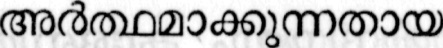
അര്‍ത്ഥമാക്കുന്നതായ
